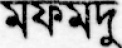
মফমদু
